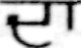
ਦਾ
